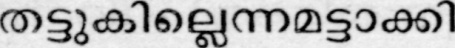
തട്ടുകില്ലെന്നമട്ടാക്കി
